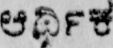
ಆರ್ಥಿಕ
